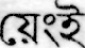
য়েংই
